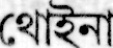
থোইনা
